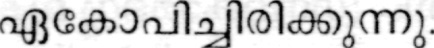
ഏകോപിച്ചിരിക്കുന്നു.
